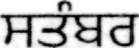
ਸਤੰਬਰ
